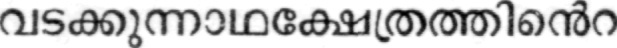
വടക്കുന്നാഥക്ഷേത്രത്തിന്റെ
